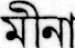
মীনা
